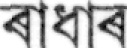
ৰাধাৰ
